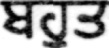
ਬਹੁਤ
